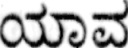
ಯಾವ
